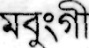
মবুংগী
